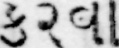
કરવા
